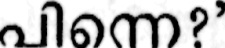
പിന്നെ?’
